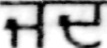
ਜਦ
